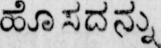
ಹೊಸದನ್ನು
